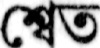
শ্বেত
